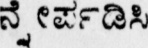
ನ್ನೇರ್ಪಡಿಸಿ
